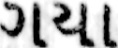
ગયા
